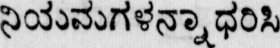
ನಿಯಮಗಳನ್ನಾಧರಿಸಿ
